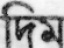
দিম
